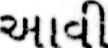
આવી
